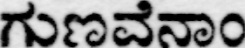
ಗುಣವೆನಾಂ
